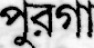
পুরগা
